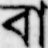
বা
